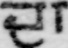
ਦਾ
